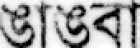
ঙাঙবা
